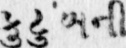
કુટુંબની
